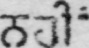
ਨਹੀਂ
